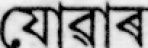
যোৱাৰ
